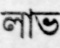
লাভ
